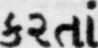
કરતાં
